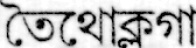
তৈথোক্লগা
